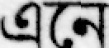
এনে
